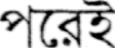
পরেই
